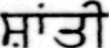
ਸ਼ਾਂਤੀ
